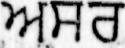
ਅਸਰ
